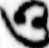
ও
